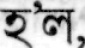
হ'ল,
